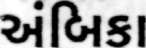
અંબિકા
